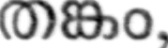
തങ്കം,
